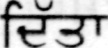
ਦਿੱਤਾ
